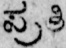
ಪ್ರತಿ
